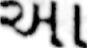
આ
